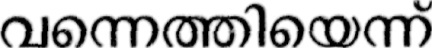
വന്നെത്തിയെന്ന്
